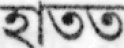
হাতত
